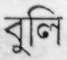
বুলি
